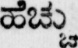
ಹೆಚ್ಚು
